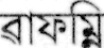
ৱাফম্নি
